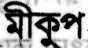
মীকুপ
